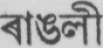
ৰাঙলী
